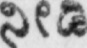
ನೀಡಿ
